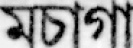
মচাগা
